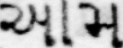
આમ
